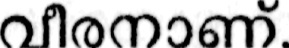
വീരനാണ്.
